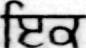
ਇਕ
